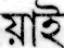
য়াই
